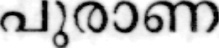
പുരാണ
